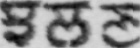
ਝਲਣ
